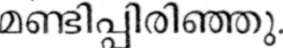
മണ്ടിപ്പിരിഞ്ഞു.
